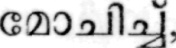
മോചിച്ച്,
